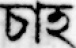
চাহ
